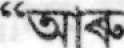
"আৰু
